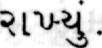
રાખ્યુ
